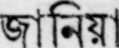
জানিয়া
